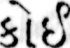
કોઈ
